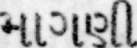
માગણી
